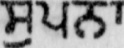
ਸੁਪਨਾ
